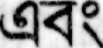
এবং
